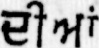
ਦੀਆਂ
